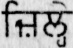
ਜ਼ਿਲ੍ਹੇ
